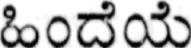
ಹಿಂದೆಯೆ
